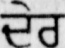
ਦੇਰ
